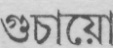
গুচায়ো
